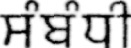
ਸੰਬੰਧੀ
